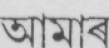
আমাৰ
